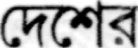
দেশের
